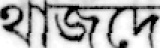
থাজদে
